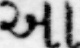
આ
